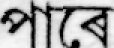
পাৰে
